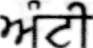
ਅੰਟੀ
